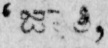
‘ಜಾತಿ,
